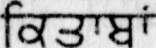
ਕਿਤਾਬਾਂ
